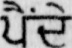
ਪੈਂਦੇ
